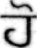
ਹੋ
